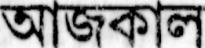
আজকাল
